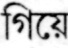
গিয়ে
